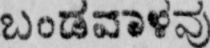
ಬಂಡವಾಳವು
